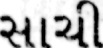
સાચી
